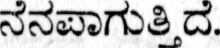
ನೆನಪಾಗುತ್ತಿದೆ.
